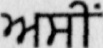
ਅਸੀਂ
